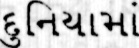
દુનિયામાં
